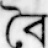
বৈ
